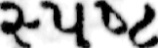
સ્પષ્ટ
